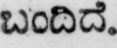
ಬಂದಿದೆ.
